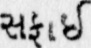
સફાઈ
